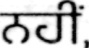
ਨਹੀਂ,
